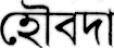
হৌবদা
